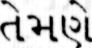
તેમણે
